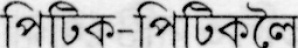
পিটিক-পিটিকলৈ
